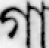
গা
